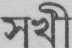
সখী
